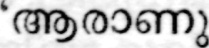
‘ആരാണു
